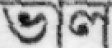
ভাল
